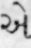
એ
